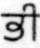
ਭੀ
